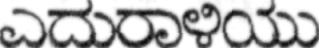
ಎದುರಾಳಿಯು
